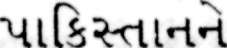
પાકિસ્તાનને
